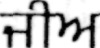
ਜੀਅ
